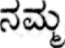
ನಮ್ಮ
